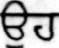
ਉਹ
